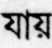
যায়
